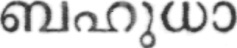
ബഹുധാ
